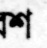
বশ
